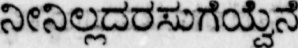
ನೀನಿಲ್ಲದರಸುಗೆಯ್ವೆನೆ
